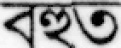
বহুত
